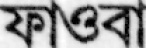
ফাওবা
